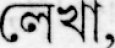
লেখা,
